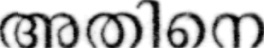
അതിനെ
